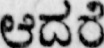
ಆದರೆ
